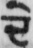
ਦੇ
